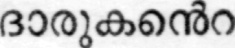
ദാരുകന്റെ
